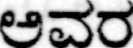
ಅವರ
